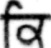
ਕਿ
